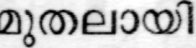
മുതലായി
